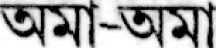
অমা-অমা
